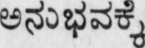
ಅನುಭವಕ್ಕೆ
